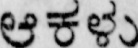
ಆಕಳು
